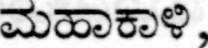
ಮಹಾಕಾಳಿ,
